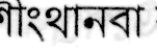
শীংথানবা
